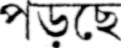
পড়ছে
